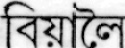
বিয়ালৈ
